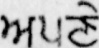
ਅਪਣੇ
